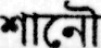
শানৌ
